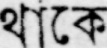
থাকে
